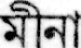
মীনা
